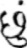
છું
